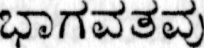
ಭಾಗವತವು
